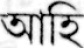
আহি
